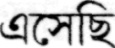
এসেছি
